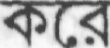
করে
